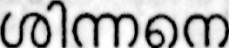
ശിന്നനെ
